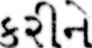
કરીને
